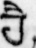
ਹੈ,
